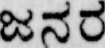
ಜನರ
